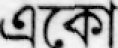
একো
